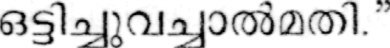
ഒട്ടിച്ചുവച്ചാല്‍മതി."
